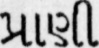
પ્રાણી
